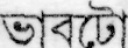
ভাবটো
